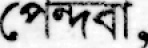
পেন্দবা,
